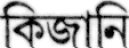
কিজানি
